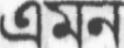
এমন
